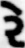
રે
